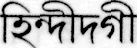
হিন্দীদগী
